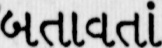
બતાવતાં
